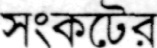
সংকটের
